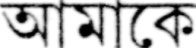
আমাকে
